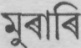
মুৰাৰি
